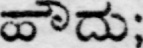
ಹೌದು;
